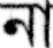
না
